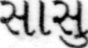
સાસુ
